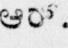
ಆರ್.
